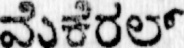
ಮೆಕೆರಲ್
